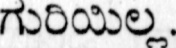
ಗುರಿಯಿಲ್ಲ.
